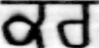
ਕਰ
